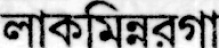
লাকমিন্নরগা
